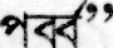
পর্ব্ব”
